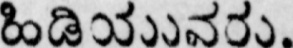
ಹಿಡಿಯುವರು.
